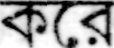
করে
